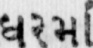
ઘરમાં
